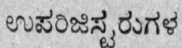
ಉಪರಿಜಿಸ್ಟರುಗಳ
